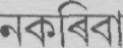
নকৰিবা
